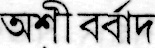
অশীর্ব্বাদ
